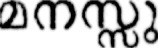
മനസ്സു
